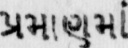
પ્રમાણમાં
